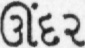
ઊંદર
